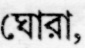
ঘোরা,
